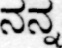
ನನ್ನ
